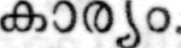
കാര്യം.
